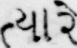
ત્યારે
